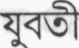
যুবতী
